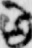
છે
